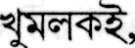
খুমলকই,
